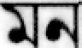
মন
